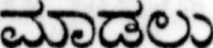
ಮಾಡಲು
